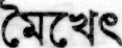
মৈখেৎ
